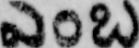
ಎಂಬ
